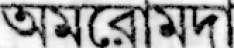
অমরোমদা
